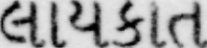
લાયકાત
